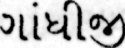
ગાંધીજી
